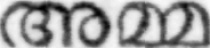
അമ്മ
